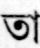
তা
